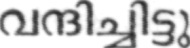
വന്ദിച്ചിട്ടു
